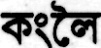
কংলৈ
